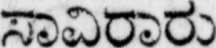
ಸಾವಿರಾರು
